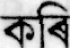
কৰি
